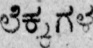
ಲೆಕ್ಕಗಳ
